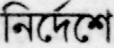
নির্দেশে
